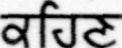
ਕਹਿਣ
